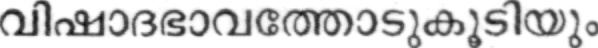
വിഷാദഭാവത്തോടുകൂടിയും
